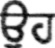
ਉਹ
